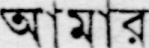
আমার
